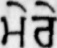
ਮੇਰੇ
